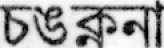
চঙক্ননা
